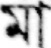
মা
